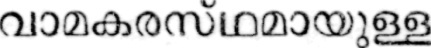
വാമകരസ്ഥമായുള്ള
